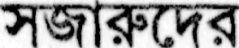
সজারুদের
